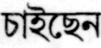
চাইছেন
